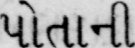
પોતાની
